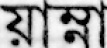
য়াম্না
